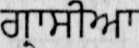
ਗ੍ਰਾਸੀਆ
